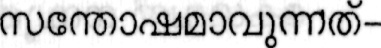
സന്തോഷമാവുന്നത്-
